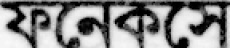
ফনেকসে
